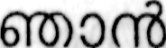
ഞാന്‍
